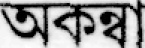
অকন্বা
